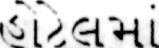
હોટેલમાં
